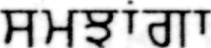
ਸਮਝਾਂਗਾ
